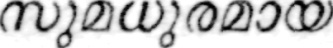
സുമധുരമായ
